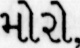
મોરો,
